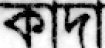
কাদা
